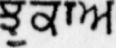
ਝੁਕਾਅ
